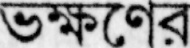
ভক্ষণের
